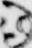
છે
